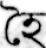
হৈ
